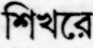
শিখরে
